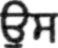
ਉਸ
